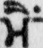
ਮੈਂ
